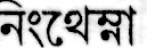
নিংথেম্না
